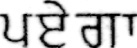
ਪਏਗਾ
